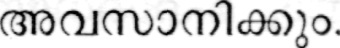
അവസാനിക്കും.
